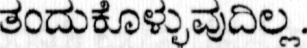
ತಂದುಕೊಳ್ಳುವುದಿಲ್ಲ.
